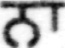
ਨਾ
